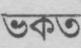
ভকত
